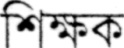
শিক্ষক
